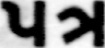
પત્ર
